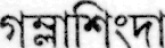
গম্লাশিংদা
